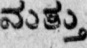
ಮತ್ತು
